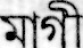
মাগী
